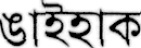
ঙাইহাক
